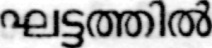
ഘട്ടത്തില്‍
